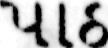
પાઠ
